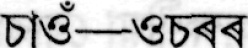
চাওঁ-ওচৰৰ
